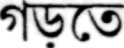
গড়তে
